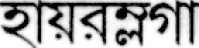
হায়রম্লগা
